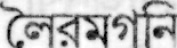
লৈরমগনি
